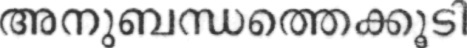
അനുബന്ധത്തെക്കൂടി
